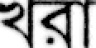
খরা
